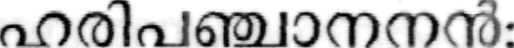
ഹരിപഞ്ചാനനന്‍:
